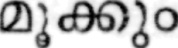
മൂക്കും
